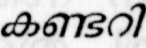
കണ്ടറി
